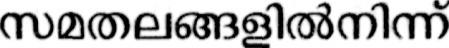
സമതലങ്ങളില്‍നിന്ന്
